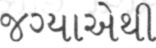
જગ્યાએથી
